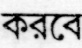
করবে
